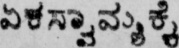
ಏಕಸ್ವಾಮ್ಯಕ್ಕೆ
